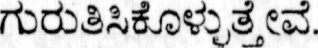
ಗುರುತಿಸಿಕೊಳ್ಳುತ್ತೇವೆ.
